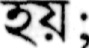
হয়;
